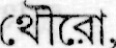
থৌরো,
